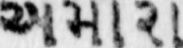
અમારા
